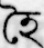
হৈ
